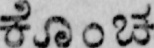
ಕೊಂಚ
